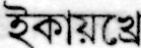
ইকায়খ্রে
